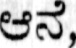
ಆನೆ,
